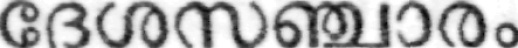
ദേശസഞ്ചാരം
